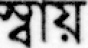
স্বায়
